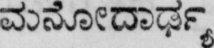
ಮನೋದಾರ್ಢ್ಯ
